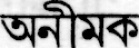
অনীমক
